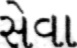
સેવા
